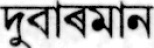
দুবাৰমান
